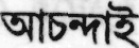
আনন্দাই
